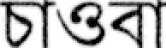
চাওবা
